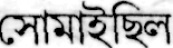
সোমাইছিল
